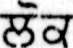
ਲੋਕ
